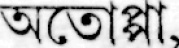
অতোপ্পা,
